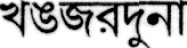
খঙজরদুনা
